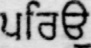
ਪਰਿਉ
